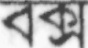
বক্স
